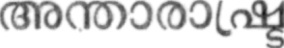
അന്താരാഷ്ട്ര
